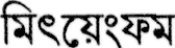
মিৎয়েংফম
